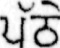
ਪੱਠੇ
